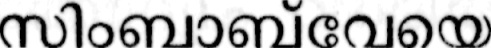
സിംബാബ്വേയെ
